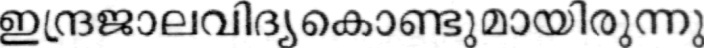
ഇന്ദ്രജാലവിദ്യകൊണ്ടുമായിരുന്നു
